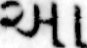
આ
